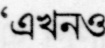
‘এখনও
